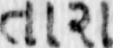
તારા
